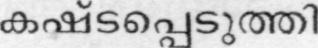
കഷ്ടപ്പെടുത്തി
